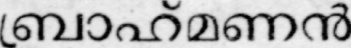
ബ്രാഹ്മണന്‍
